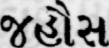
જહૌસ
